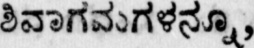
ಶಿವಾಗಮಗಳನ್ನೂ,
